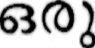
ഒരു
